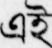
এই
